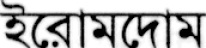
ইরোমদোম
